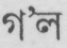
গ'ল
